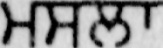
ਮਸਲਾ
